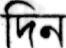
দিন
